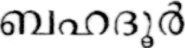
ബഹദൂര്‍
